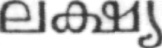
ലക്ഷ്യ
